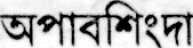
অপাবশিংদা
